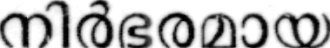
നിര്‍ഭരമായ
